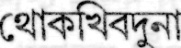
থোকখিবদুনা
